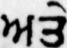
ਅਤੇ
